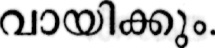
വായിക്കും.
